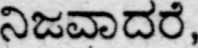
ನಿಜವಾದರೆ,
